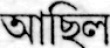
আছিল
